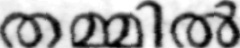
തമ്മില്‍
